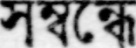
সম্বন্ধে
